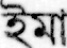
ইমা
